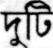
দুটি
